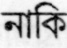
নাকি
